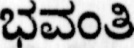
ಭವಂತಿ
